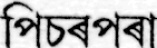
পিচৰপৰা
